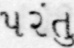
પરંતુ
